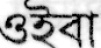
ওইবা
